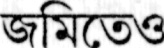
জমিতেও
